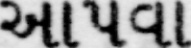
આપવા
